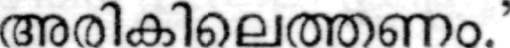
അരികിലെത്തണം.’
